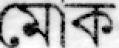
মোক
